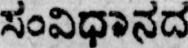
ಸಂವಿಧಾನದ
